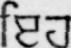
ਇਹ
